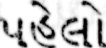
પહેલો
